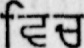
ਵਿਚ
